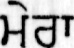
ਮੇਰਾ
